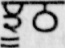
ਝੂਠ
